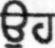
ਉਹ
